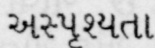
અસ્પૃશ્યતા
